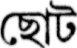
ছোট
